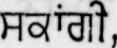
ਸਕਾਂਗੀ,
